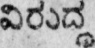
ವಿರುದ್ಧ
